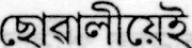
ছোৱালীয়েই
